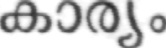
കാര്യം
